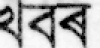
খবৰ
